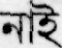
নাই
